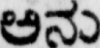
ಅನು
